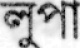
লুপা
